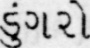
ડુંગરો
